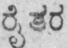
ರೈತರ
